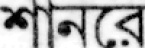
শানরে
